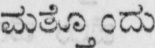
ಮತ್ತೊಂದು
